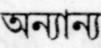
অন্যান্য
